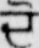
ਦੋ
